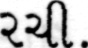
રચી.
